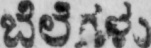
ಬೆಲೆಗಳು
